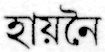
হায়নৈ
